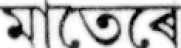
মাতেৰে
